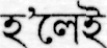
হ'লেই
